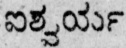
ಐಶ್ವರ್ಯ
